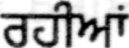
ਰਹੀਆਂ
